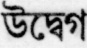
উদ্বেগ
